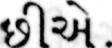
છીએ.
